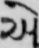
એ
